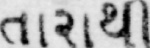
તારાથી
